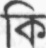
কি
